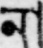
না
